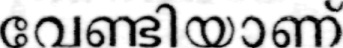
വേണ്ടിയാണ്
